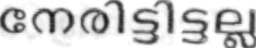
നേരിട്ടിട്ടല്ല
